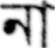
না
